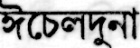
ঈচেলদুনা
